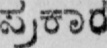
ಪ್ರಕಾರ
